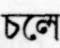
চলে
